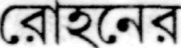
রোহনের
